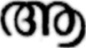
ആ
